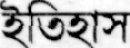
ইতিহাস
